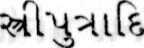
સ્ત્રીપુત્રાદિ
